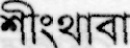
শীংথাবা
